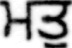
ਮਤੁ
